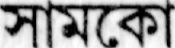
সামকো
